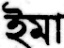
ইমা
